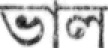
ভাল
